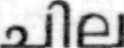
ചില
